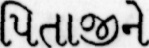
પિતાજીને
